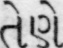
તેણે
